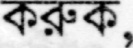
করুক,
